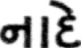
નાદે
